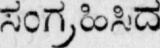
ಸಂಗ್ರಹಿಸಿದ
